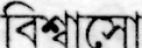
বিশ্বাসো
